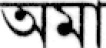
অমা
